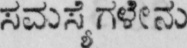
ಸಮಸ್ಯೆಗಳೇನು
